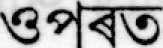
ওপৰত
